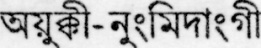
অয়ুক্কী-নুমিদাংগী
